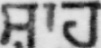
ਸ਼ਾਹ
